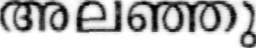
അലഞ്ഞു
